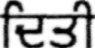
ਦਿਤੀ
